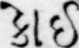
કોઈ
